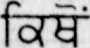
ਕਿਥੋਂ
